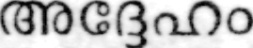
അദ്ദേഹം
